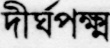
দীর্ঘপক্ষ্ম
